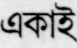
একাই
